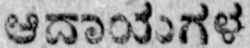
ಅದಾಯಗಳ
